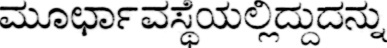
ಮೂರ್ಛಾವಸ್ಥೆಯಲ್ಲಿದ್ದುದನ್ನು
